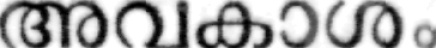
അവകാശം
